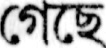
গেছে
